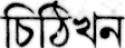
চিঠিখন
